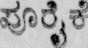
ಪೂರೈಕೆ
